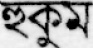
হুকুম
